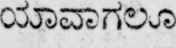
ಯಾವಾಗಲೂ
